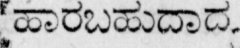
ಹಾರಬಹುದಾದ.
